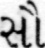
સૌ
